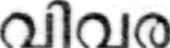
വിവര
